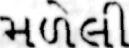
મળેલી
